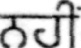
ਨਹੀਂ
